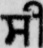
ਸੀ
